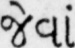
જેવાં
